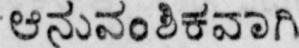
ಅನುವಂಶಿಕವಾಗಿ
